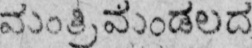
ಮಂತ್ರಿಮಂಡಲದ
